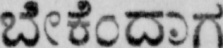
ಬೇಕೆಂದಾಗ
